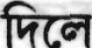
দিলে
